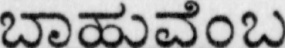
ಬಾಹುವೆಂಬ
